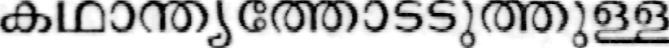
കഥാന്ത്യത്തോടടുത്തുള്ള
